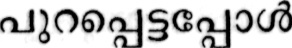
പുറപ്പെട്ടപ്പോള്‍
